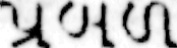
પ્રબળ
